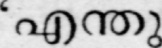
'എന്തു
